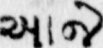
આજે
